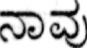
ನಾವು
